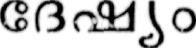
ദേഷ്യം
